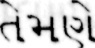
તેમણે
